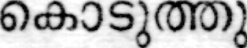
കൊടുത്തു
